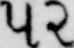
પર
